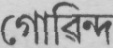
গোৱিন্দ
